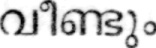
വീണ്ടും
